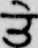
ਤੇ
